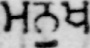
ਮਨੁਖ
